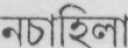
নচাহিলা
